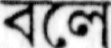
বলে
